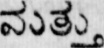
ಮತ್ತು
